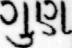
ગુણ
